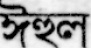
ইহুল
